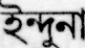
ইন্দুনা
